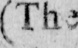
(The
